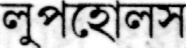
লুপহোলস
